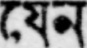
যেন
